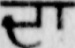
ਦਾ
